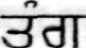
ਤੰਗ
